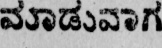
ಮಾಡುವಾಗ
